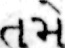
તમે
